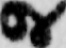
જ
